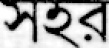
সহর
